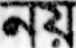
নয়
